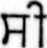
ਸੀ
